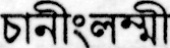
চানীংলম্মী
